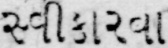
સ્વીકારવા
